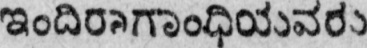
ಇಂದಿರಾಗಾಂಧಿಯವರು
